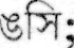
ঙসি;
